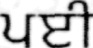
ਪਈ
